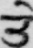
ਤੇ
